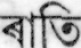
ৰাতি
